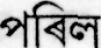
পৰিল
